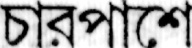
চারপাশে
